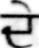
ਦੇ
